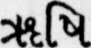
ૠષિ
